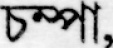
চম্পা,
